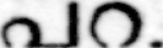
പറ.
